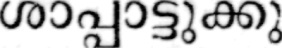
ശാപ്പാട്ടുക്കു
